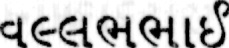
વલ્લભભાઈ
